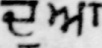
ਦੁਆ
